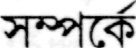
সম্পর্কে
